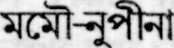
মমৌ-নুপীনা
